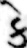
કે
